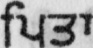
ਪਿਤਾ
